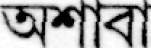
অশাবা
